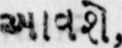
આવશે,
